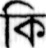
কি
